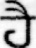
ਹੈ
